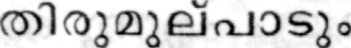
തിരുമുല്പാടും
